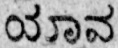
ಯಾವ
